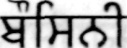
ਬੌਸਿਨੀ
